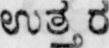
ಉತ್ತರ
